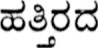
ಹತ್ತಿರದ
